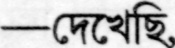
–দেখেছি,
